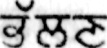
ਭੱਲਣ
